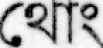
থোং
